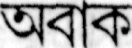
অবাক
